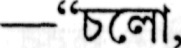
-"চলো,
